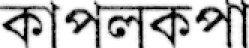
কাপলকপা
